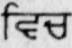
ਵਿਚ
